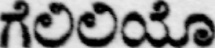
ಗೆಲಿಲಿಯೊ
